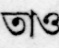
তাও
